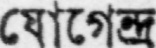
যোগেন্দ্র
